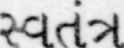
સ્વતંત્ર
